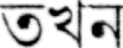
তখন
